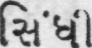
સિંધી
